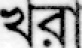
খরা
